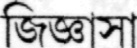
জিজ্ঞাসা
